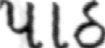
પાઠ
